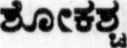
ಶೋಕಶ್ಚ
